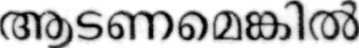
ആടണമെങ്കില്‍
